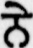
ਨੇ
